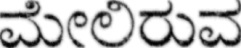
ಮೇಲಿರುವ
